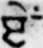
ਏਂ
